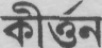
কীৰ্ত্তন
